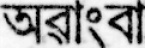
অৱাংবা
